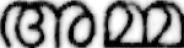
അമ്മ
